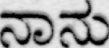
ನಾನು
